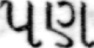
પણ
